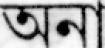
অনা
